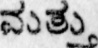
ಮತ್ತು
